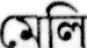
মেলি
